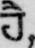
ਹੈ,
